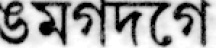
ঙমগদগে
